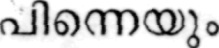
പിന്നെയും
